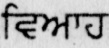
ਵਿਆਹ
